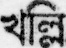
খল্লি
